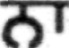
ਨਾ
